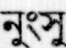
নুংসু
